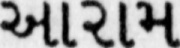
આરામ
